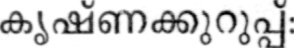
കൃഷ്ണക്കുറുപ്പ്:
